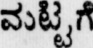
ಮಟ್ಟಿಗೆ
